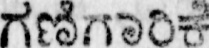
ಗಣಿಗಾರಿಕೆ
